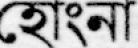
হোংনা
